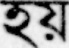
হয়
